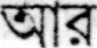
আর
